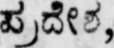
ಪ್ರದೇಶ,
